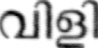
വിളി
